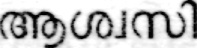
ആശ്വസി
